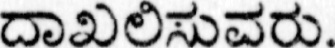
ದಾಖಲಿಸುವರು.
